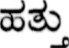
ಹತ್ತು
